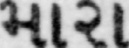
મારા
